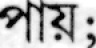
পায়;
